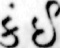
કંઈ
